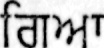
ਗਿਆ
